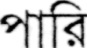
পারি
